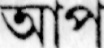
আপ
